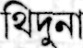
থিদুনা
